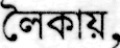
লৈকায়,
